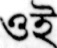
ওই
